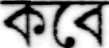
কবে
